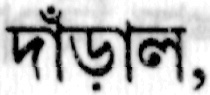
দাঁড়াল,
